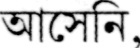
আসেনি,
